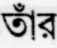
তাঁর
